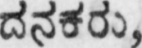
ದನಕರು,
